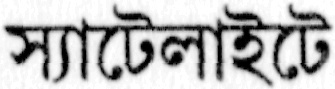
স্যাটেলাইটে
